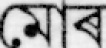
মোৰ
